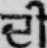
ਦੀ
